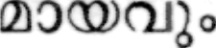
മായവും
